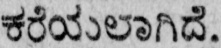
ಕರೆಯಲಾಗಿದೆ.
